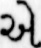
એ
